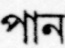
পান
